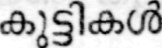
കുട്ടികള്‍
